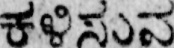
ಕಳಿಸುವ
